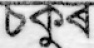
চকুৰ
